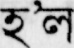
হ'ল
